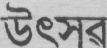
উৎসৱ
